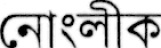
নোংলীক
